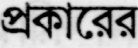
প্রকারের
